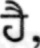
ਹੈ,
